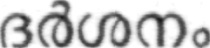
ദര്‍ശനം
